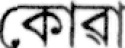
কোৱা
